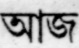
আজ
